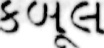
કબૂલ
